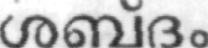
ശബ്ദം
